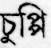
চুপ্পি
